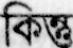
কিন্তু
